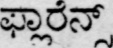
ಫ್ಲಾರೆನ್ಸ್
